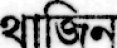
থাজিন
